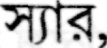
স্যার,
